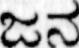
ಜನ
